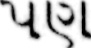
પણ
